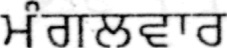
ਮੰਗਲਵਾਰ
